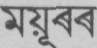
ময়ূৰৰ
